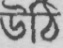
উঠি
